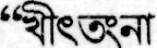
“খীৎতংনা
